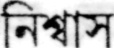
নিশ্বাস
